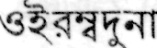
ওইরম্বদুনা
